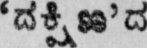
‘ದಕ್ಷಿಣ’ದ
